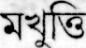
মখুত্তি
